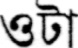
ওটা
